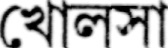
খোলসা
